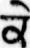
ਕੇ
